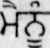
ਮੈਨੂੰ
